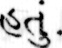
હતું.
